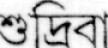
শুদ্রিবা
